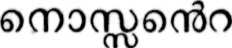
നൊസ്സന്റെ
